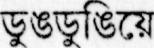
ডুঙডুঙিয়ে
